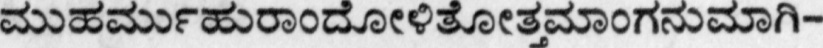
ಮುಹರ್ಮುಹುರಾಂದೋಳಿತೋತ್ತಮಾಂಗನುಮಾಗಿ-
